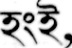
হংই,
